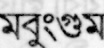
মবুংগুম
